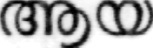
ആയ
